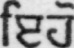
ਇਹੋ
